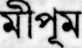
মীপূম
